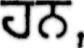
ਹਨ,
